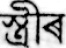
স্ত্রীৰ
